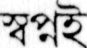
স্বপ্নই
